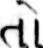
તો
